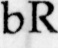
bR
